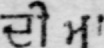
ਦੀਆ
